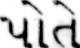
પોતે
